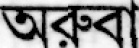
অরুবা
